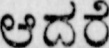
ಆದರೆ
